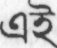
এই
